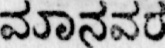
ಮಾನವರ
